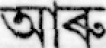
আৰু
